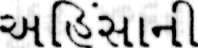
અહિંસાની
